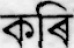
কৰি
